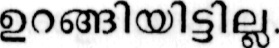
ഉറങ്ങിയിട്ടില്ല.
